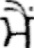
ਮੈਂ
